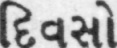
દિવસો
